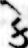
કે
